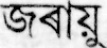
জৰায়ু
